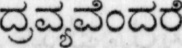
ದ್ರವ್ಯವೆಂದರೆ
